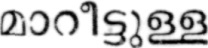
മാറീട്ടുള്ള
